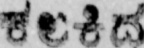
ಕಲಕಿದ
